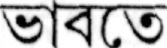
ভাবতে
